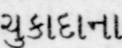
ચુકાદાના
